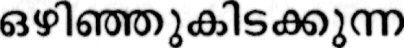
ഒഴിഞ്ഞുകിടക്കുന്ന
